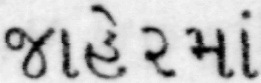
જાહેરમાં
